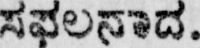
ಸಫಲನಾದ.
